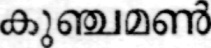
കുഞ്ചമണ്‍
